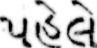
પહેલે
